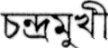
চন্দ্রমুখী
